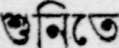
শুনিতে
